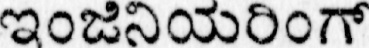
ಇಂಜಿನಿಯರಿಂಗ್
